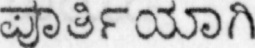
ಪೂರ್ತಿಯಾಗಿ
